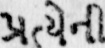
પ્રત્યેની
